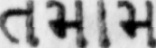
તમામ
